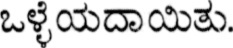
ಒಳ್ಳೆಯದಾಯಿತು.
